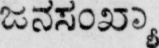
ಜನಸಂಖ್ಯಾ
